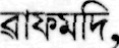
ৱাফমদি,
